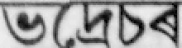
ভদ্ৰেচৰ
